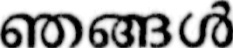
ഞങ്ങള്‍
